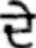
ਦੇ
